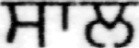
ਸਾਲ
